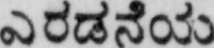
ಎರಡನೆಯ
